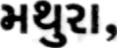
મથુરા,
